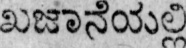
ಖಜಾನೆಯಲ್ಲಿ
